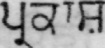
ਪ੍ਰਕਾਸ਼
